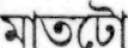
মাতটো
